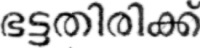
ഭട്ടതിരിക്ക്
